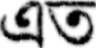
এত
